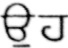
ਉਹ
